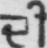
ਦੀ
